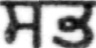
ਸਭ
